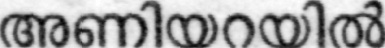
അണിയറയില്‍
